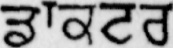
ਡਾਕਟਰ
